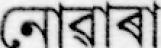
নোৱাৰা
